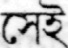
সেই
